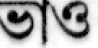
ভাও
